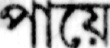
পায়ে
